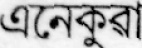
এনেকুৱা
